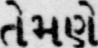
તેમણે
